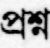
প্রশ্ন
